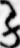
કે
